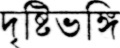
দৃষ্টিভঙ্গি
